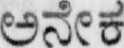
ಅನೇಕ
